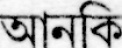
আনকি
